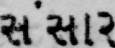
સંસાર
